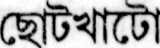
ছোটখাটো
